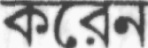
করেন
